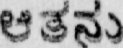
ಆತನು
